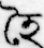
হৈ
